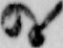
જ
